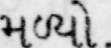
મળ્યો.
